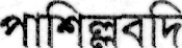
পাশিল্লবদি
